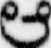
ಆ
